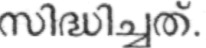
സിദ്ധിച്ചത്.
